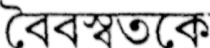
বৈবস্বতকে
